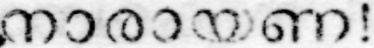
നാരായണ!
